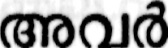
അവര്‍
